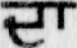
ਦਾ
